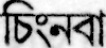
চিংনবা
